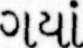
ગયાં
